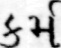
કર્મ
